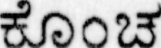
ಕೊಂಚ
